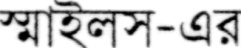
স্মাইলস-এর
